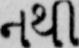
નથી
